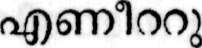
എണീററു
